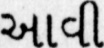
આવી
